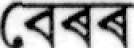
বেৰৰ
